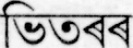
ভিতৰৰ
